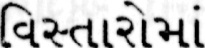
વિસ્તારોમાં
